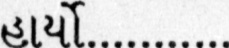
હાર્યો...........
